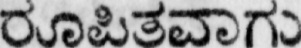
ರೂಪಿತವಾಗು
